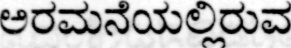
ಅರಮನೆಯಲ್ಲಿರುವ
